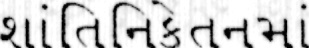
શાંતિનિકેતનમાં
